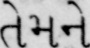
તેમને
